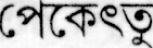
পেকেৎতু
